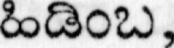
ಹಿಡಿಂಬ,
